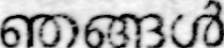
ഞങ്ങള്‍
